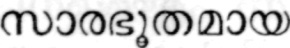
സാരഭൂതമായ
